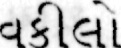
વકીલો
